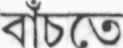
বাঁচতে
